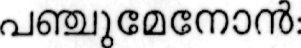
പഞ്ചുമേനോന്‍:
